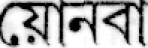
য়োনবা
